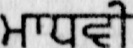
ਮਾਧਵੀ
